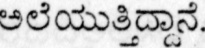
ಅಲೆಯುತ್ತಿದ್ದಾನೆ.
